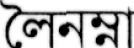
লৈনম্না
